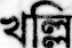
খল্লি
